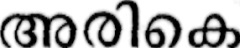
അരികെ
